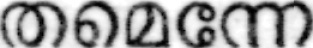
തമെന്നേ
